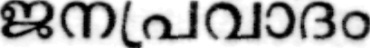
ജനപ്രവാദം
